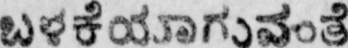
ಬಳಕೆಯಾಗುವಂತೆ
